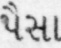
પૈસા
